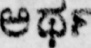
ಅರ್ಥ
